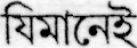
যিমানেই
